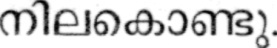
നിലകൊണ്ടു.
